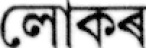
লোকৰ
